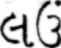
લઉં
